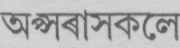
অপ্সৰাসকলে
